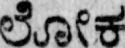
ಲೋಕ
